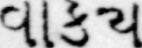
વાક્ય
